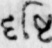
દષ્ટિ
